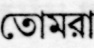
তোমরা
